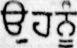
ਉਹਨੂੰ
